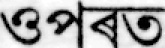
ওপৰত
